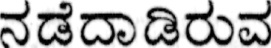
ನಡೆದಾಡಿರುವ
